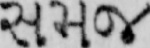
સમજ
